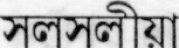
সলসলীয়া
